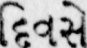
દિવસે
